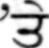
'ਤੇ
